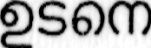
ഉടനെ
